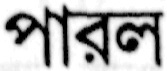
পারল
